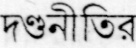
দণ্ডনীতির
